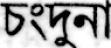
চংদুনা
